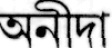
অনীদা
